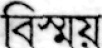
বিস্ময়
